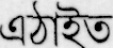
এঠাইত
